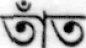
তাঁত
